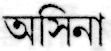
অসিনা
